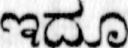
ಇದೂ
